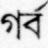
গর্ব
